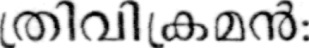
ത്രിവിക്രമന്‍:
